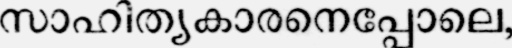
സാഹിത്യകാരനെപ്പോലെ,
